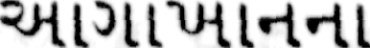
આગાખાનના
